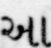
આ
